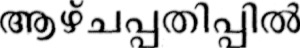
ആഴ്ചപ്പതിപ്പില്‍
